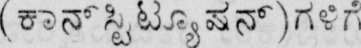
(ಕಾನ್ ಸ್ಟಿಟ್ಯೂಷನ್)ಗಳಿಗೆ
